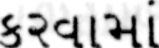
કરવામાં
